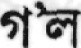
গ'ল
